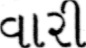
વારી
